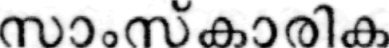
സാംസ്കാരിക
